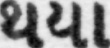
થયા
